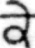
ਕੇ
